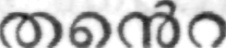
തന്റെ
